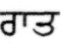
ਰਾਤ
